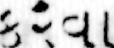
કરવા
